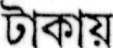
টাকায়
